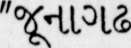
"જૂનાગઢ
